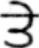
ਤੇ
